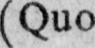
(Quo
